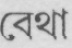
বেথা
